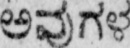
ಅವುಗಳ
